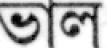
ভাল
